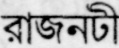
রাজনটী
